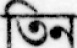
তিন
